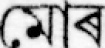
মোৰ
